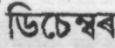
ডিচেম্বৰ
